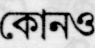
কোনও
